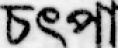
চৎপা
